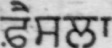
ਫ਼ੈਸਲਾ
